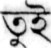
তুই
